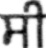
ਸੀ
